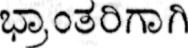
ಭ್ರಾಂತರಿಗಾಗಿ
